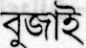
বুজাই
